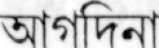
আগদিনা
